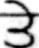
ਤੇ
